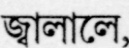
জ্বালালে,
